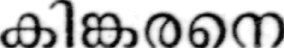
കിങ്കരനെ
